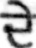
ਦੇ
